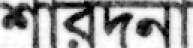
শারদনা
